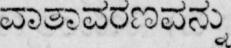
ವಾತಾವರಣವನ್ನು
